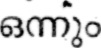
ഒന്നും
